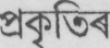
প্রকৃতিৰ
